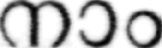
നാം
